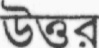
উত্তর
